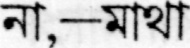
না,—মাথা
